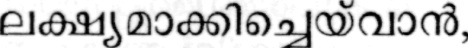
ലക്ഷ്യമാക്കിച്ചെയ്വാന്‍,
